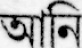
আনি
